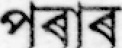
পৰাৰ
